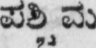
ಪಶ್ಚಿಮ
